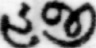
હજી
